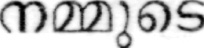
നമ്മുടെ
